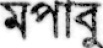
মপাবু
